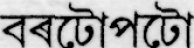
বৰটোপটো
